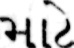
માટે
